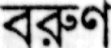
বরুণ
